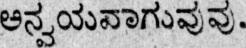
ಅನ್ವಯವಾಗುವುವು.
